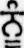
ਨੂੰ
